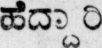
ಹೆದ್ದಾರಿ
